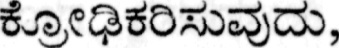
ಕ್ರೋಢಿಕರಿಸುವುದು,
